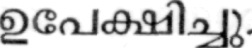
ഉപേക്ഷിച്ചു.
